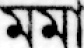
মমা
